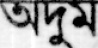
অদুম
